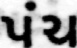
પંચ
